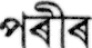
পৰীৰ
